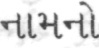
નામનો
